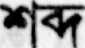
শব্দ
